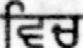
ਵਿਚ
